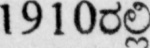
1910ರಲ್ಲಿ
